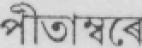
পীতাম্বৰে
